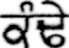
ਕੰਢੇ
